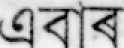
এবাৰ
